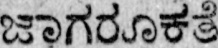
ಜಾಗರೂಕತೆ
